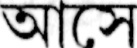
আসে
